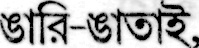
ঙারি-ঙাতাই,
